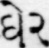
ઘેર
